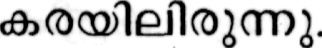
കരയിലിരുന്നു.
